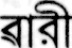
ৱারী
